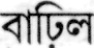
বাঢ়িল
